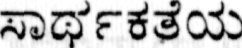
ಸಾರ್ಥಕತೆಯ
